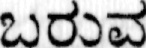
ಬರುವ
